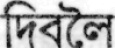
দিবলৈ
